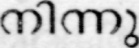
നിന്നു
